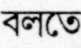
বলতে
